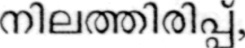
നിലത്തിരിപ്പ്,
